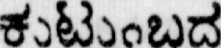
ಕುಟುಂಬದ
